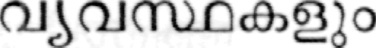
വ്യവസ്ഥകളും
